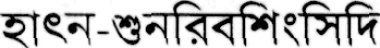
হাৎন-শুনরিবশিংসিদি
